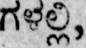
ಗಳಲ್ಲಿ,
